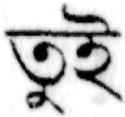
তুই
